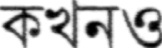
কখনও
